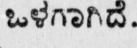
ಒಳಗಾಗಿದೆ.
